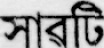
সাৱটি
